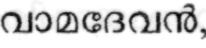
വാമദേവന്‍,
